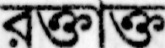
রক্তাক্ত
